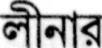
লীনার
